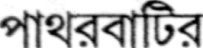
পাথরবাটির
